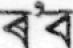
ৰ'ব
